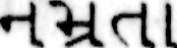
નમ્રતા
